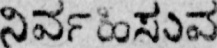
ನಿರ್ವಹಿಸುವ
